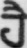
ਹੈ
